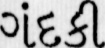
ગંદકી
